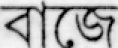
বাজে
